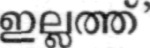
ഇല്ലത്ത്'
